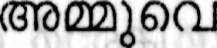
അമ്മുവെ
